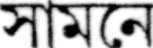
সামনে
